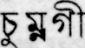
চুম্নগী
